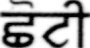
ਛੋਟੀ
